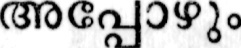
അപ്പോഴും
